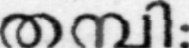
തമ്പി:
